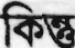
কিন্তু
